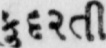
કુદરતી
